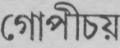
গোপীচয়
